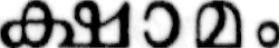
ക്ഷാമം
